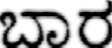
ಬಾರ
